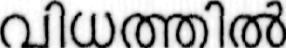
വിധത്തില്‍
